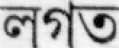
লগত
